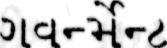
ગવર્ન્મેન્ટ
